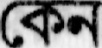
কেন
